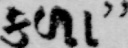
કળા”
